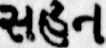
સહન
